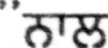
''ਨਾਲ
